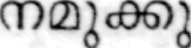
നമുക്കു
